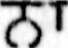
ਨਾ
